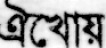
ঐখোয়
